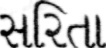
સરિતા
